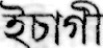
ইচাগী
